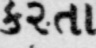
કરતા
